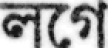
লগে
